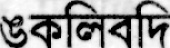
ঙকলিবদি
